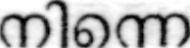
നിന്നെ
